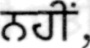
ਨਹੀਂ,
